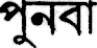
পুনবা
